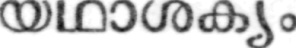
യഥാശക്യം
